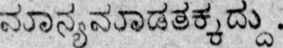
ಮಾನ್ಯಮಾಡತಕ್ಕದ್ದು.
